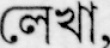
লেখা,
